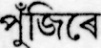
পুঁজিৰে
